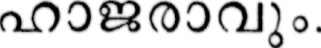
ഹാജരാവും.
